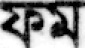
ফম
